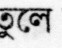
তুলে
